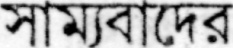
সাম্যবাদের
